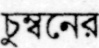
চুম্বনের
